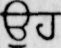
ਉਹ
